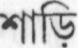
শাড়ি
